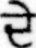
ਦੇ
